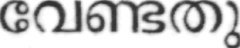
വേണ്ടതു
